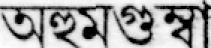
অহুমগুম্বা
